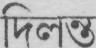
দিলন্ত
